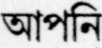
আপনি
